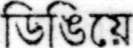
ডিঙিয়ে
